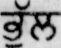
ਭੁੱਲ
